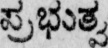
ಪ್ರಭುತ್ವ
